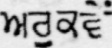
ਅਰੁਕਵੇਂ
